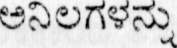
ಅನಿಲಗಳನ್ನು
